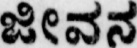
ಜೀವನ
